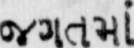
જગતમાં
